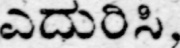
ಎದುರಿಸಿ,
